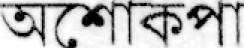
অশোকপা
